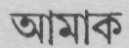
আমাক
